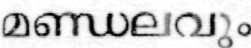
മണ്ഡലവും
